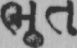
ભુત
